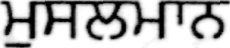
ਮੁਸਲਮਾਨ
